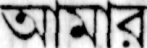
আমার
